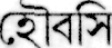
হৌবসি
